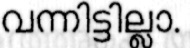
വന്നിട്ടില്ലാ.
